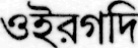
ওইরগদি
